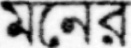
মনের
